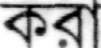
করা
